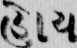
હોય
